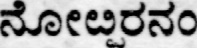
ನೋೞ್ಪರನಂ
